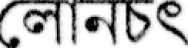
লোনচৎ
